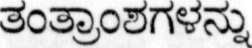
ತಂತ್ರಾಂಶಗಳನ್ನು
